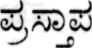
ಪ್ರಸ್ತಾಪ
